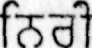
ਨਿਰੀ
